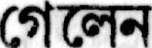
গেলেন।
